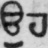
ਉਹ
